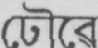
ঢৌৱে
